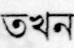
তখন
